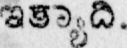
ಇತ್ಯಾದಿ.
